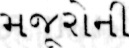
મજૂરોની
